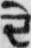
ਦੇ
